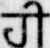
ਹੀ
